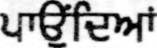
ਪਾਉਂਦਿਆਂ
